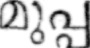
മുപ്പ
